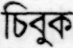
চিবুক
